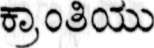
ಕ್ರಾಂತಿಯು
